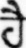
ਹੈ
